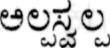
ಅಲ್ಪಸ್ವಲ್ಪ
